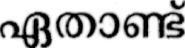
ഏതാണ്ട്
